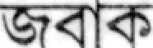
জবাক
